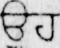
ਉਹ
